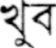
খুব
